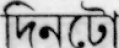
দিনটো
